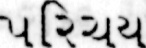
પરિચય
